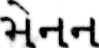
મેનન
